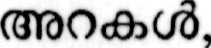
അറകള്‍,
